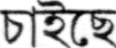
চাইছে
